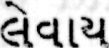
લેવાય
